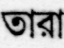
তারা
